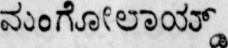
ಮಂಗೋಲಾಯ್ಡ್
